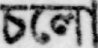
চলো
